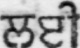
ਲਈ
